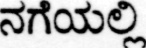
ನಗೆಯಲ್ಲಿ
